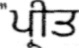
''ਪ੍ਰੀਤ
